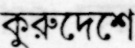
কুরুদেশে
